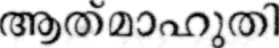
ആത്മാഹുതി
